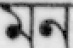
মন
